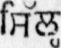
ਸਿੱਲ੍ਹ
